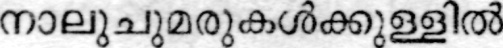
നാലുചുമരുകള്‍ക്കുള്ളില്‍
